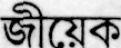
জীয়েক
